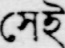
সেই
